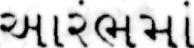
આરંભમાં
